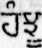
ਹੰਝੂ
